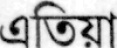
এতিয়া
